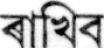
ৰাখিব
